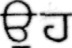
ਉਹ
